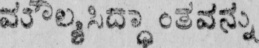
ಮೌಲ್ಯಸಿದ್ಧಾಂತವನ್ನು
